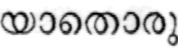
യാതൊരു
